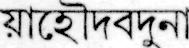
য়াহৌদবদুনা
